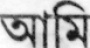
আমি
